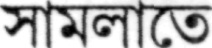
সামলাতে
